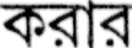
করার
